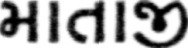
માતાજી
